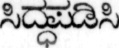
ಸಿದ್ಧಪಡಿಸಿ
